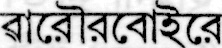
ৱারৌরবোইরে
